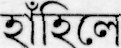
হাঁহিলে
